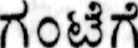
ಗಂಟೆಗೆ
